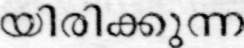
യിരിക്കുന്ന
